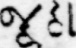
જૂઠા
